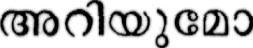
അറിയുമോ
